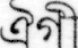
ঐগী
